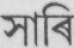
সাৰি
